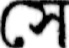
সে
